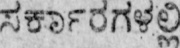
ಸರ್ಕಾರಗಳಲ್ಲಿ
